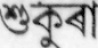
শুকুৰা
